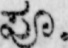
ಪೂ.
